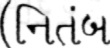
(નિતંબ
